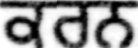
ਕਰਨ
